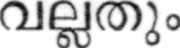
വല്ലതും
